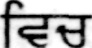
ਵਿਚ
